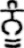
ਨੂੰ
